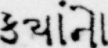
ક્યાંનો
